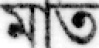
মাত
